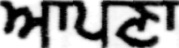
ਆਪਣਾ
